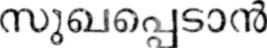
സുഖപ്പെടാന്‍
